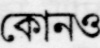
কোনও
